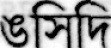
ঙসিদি
